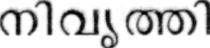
നിവൃത്തി
